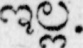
ಇಲ್ಲ.
